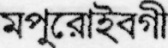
মপুরোইবগী
